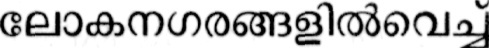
ലോകനഗരങ്ങളില്‍വെച്ച്
